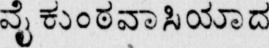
ವೈಕುಂಠವಾಸಿಯಾದ
